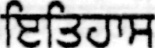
ਇਤਿਹਾਸ
